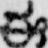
ಈ
